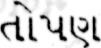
તોપણ
